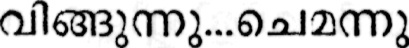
വിങ്ങുന്നു...ചെമന്നു
